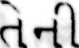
તેની
